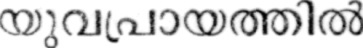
യുവപ്രായത്തില്‍
